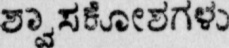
ಶ್ವಾಸಕೋಶಗಳು
